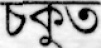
চকুত
